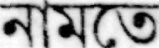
নামতে
